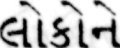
લોકોને
